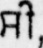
ਸੀ,
